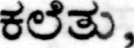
ಕಲೆತು,
